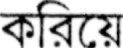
করিয়ে
